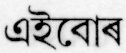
এইবোৰ
